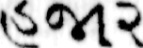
હજાર
